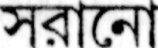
সরানো
